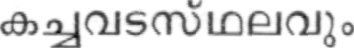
കച്ചവടസ്ഥലവും
